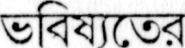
ভবিষ্যতের
